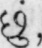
છું.
